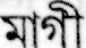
মাগী
